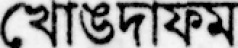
খোঙদাফম
